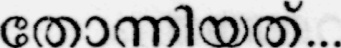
തോന്നിയത്...
